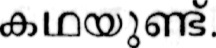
കഥയുണ്ട്.
